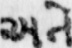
અને
